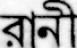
রানী
